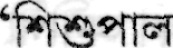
শিশুপাল
